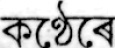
কণ্ঠেৰে
